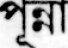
পূন্না
